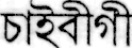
চাইবীগী
